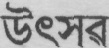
উৎসৱ
